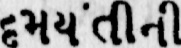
દમયંતીની
